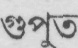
গুপুত
